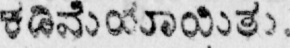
ಕಡಿಮೆಯಾಯಿತು.
